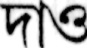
দাও
